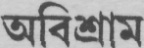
অবিশ্ৰাম
